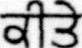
ਕੀਤੇ
